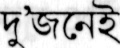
দুজনেই
